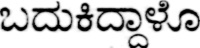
ಬದುಕಿದ್ದಾಳೊ
